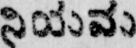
ನಿಯಮ
